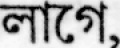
লাগে,
